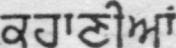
ਕਹਾਣੀਆਂ
